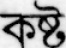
কষ্ট
